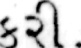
કરી.
